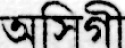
অসিগী
